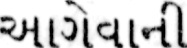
આગેવાની
